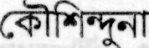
কৌশিন্দুনা
